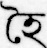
হৈ
